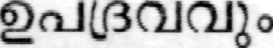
ഉപദ്രവവും
